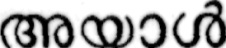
അയാള്‍
